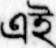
এই
